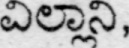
ವಿಲ್ಲಾನಿ,
